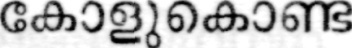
കോളുകൊണ്ട
